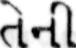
તેની
